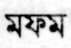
মফম
